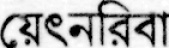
য়েৎনরিবা
